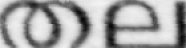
തല
